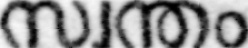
സ്വന്തം
